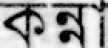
কন্না
